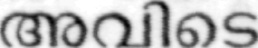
അവിടെ
